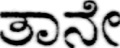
ತಾನೇ
